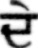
ਦੇ
